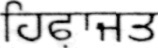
ਹਿਫ਼ਾਜਤ
